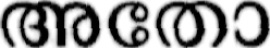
അതോ
